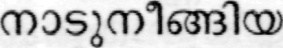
നാടുനീങ്ങിയ
